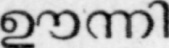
ഊന്നി
